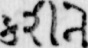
કરીને
